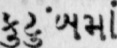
કુટુંબમાં
